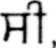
ਸੀ,
